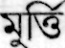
মুর্ত্তি
